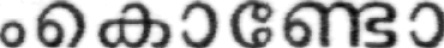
കൊണ്ടോ
